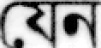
যেন
